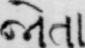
જોતા
